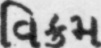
વિક્રમ
